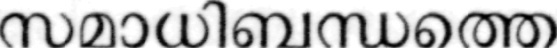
സമാധിബന്ധത്തെ
